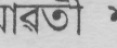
যাৱতী
